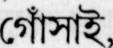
গোঁসাই,
